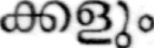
ക്കളും
